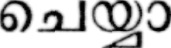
ചെയ്യാ
